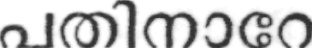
പതിനാറേ
